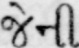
જેની
